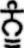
ਨੂੰ
